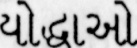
યોદ્ધાઓ
